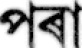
পৰা
